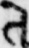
તે
